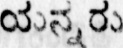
ಯನ್ನರು
